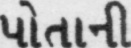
પોતાની
